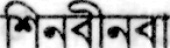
শিনবীনবা
